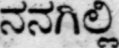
ನನಗಿಲ್ಲಿ
